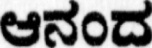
ಆನಂದ
